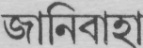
জানিবাহা
